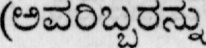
(ಅವರಿಬ್ಬರನ್ನು
